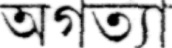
অগত্যা
